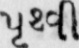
પૃથ્વી
